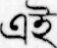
এই
